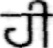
ਹੀ
